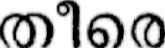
തീരെ
